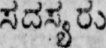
ಸದಸ್ಯರು
